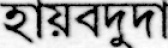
হায়বদুদা
